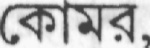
কোমর,
